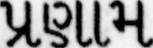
પ્રણામ
